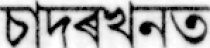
চাদৰখনত
